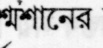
শ্মশানের
